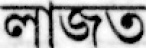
লাজত
